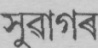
সুৱাগৰ
